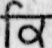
ਕਿ
